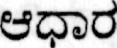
ಆಧಾರ
